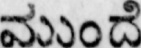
ಮುಂದೆ
